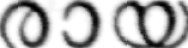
രായ
